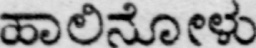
ಹಾಲಿನೋಳು
